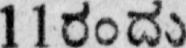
11ರಂದು
